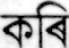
কৰি
